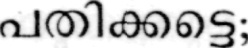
പതിക്കട്ടെ;
